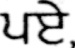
ਪਏ,
